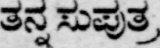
ತನ್ನಸುಪುತ್ರ
